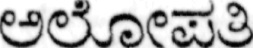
ಅಲೋಪತಿ
